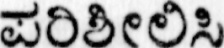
ಪರಿಶೀಲಿಸಿ
